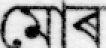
মোৰ
